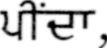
ਪੀਂਦਾ,
